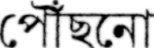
পৌছানো
